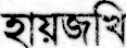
হায়জখি
